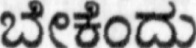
ಬೇಕೆಂದು
